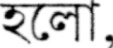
হলো,
